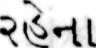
રહેના
